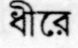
ধীরে
